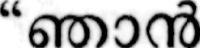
“ഞാന്‍
